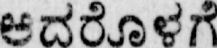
ಅದರೊಳಗೆ
